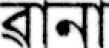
ৱানা
